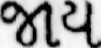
જાય
